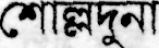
শোল্লদুনা
